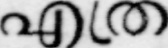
എത്ര
